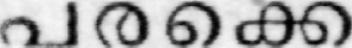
പരക്കെ
